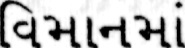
વિમાનમાં
